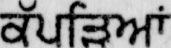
ਕੱਪੜਿਆਂ
